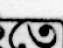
ঐদি
